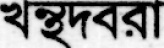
খন্থদবরা
